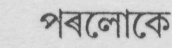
পৰলোকে
